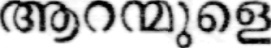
ആറന്മുളെ
